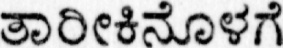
ತಾರೀಕಿನೊಳಗೆ
